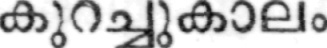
കുറച്ചുകാലം
